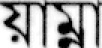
য়াম্না
